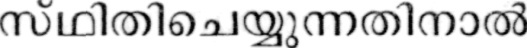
സ്ഥിതിചെയ്യുന്നതിനാല്‍
